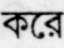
করে
